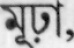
মূঢ়া,
